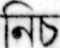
নিচ
